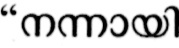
“നന്നായി
